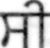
ਸੀ
